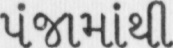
પંજામાંથી
